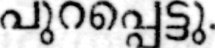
പുറപ്പെട്ടു.
